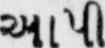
આપી
